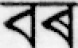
বৰ
